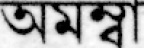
অমম্বা
